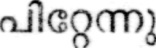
പിറ്റേന്നു
